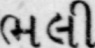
ભલી
